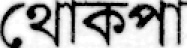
থোকপা
